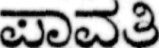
ಪಾವತಿ
